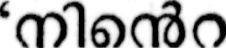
‘നിന്റെ
